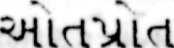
ઓતપ્રોત
